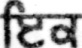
ਇਕ
